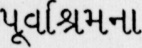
પૂર્વાશ્રમના
